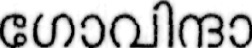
ഗോവിന്ദാ
